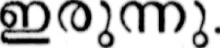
ഇരുന്നു.
